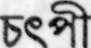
চৎপী
